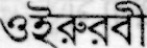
ওইরুরবী
